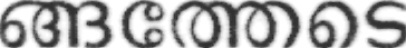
ങ്ങത്തേടെ
